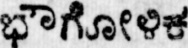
ಭೌಗೋಳಿಕ
